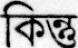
কিন্তু
